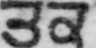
ਤਕ
